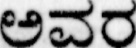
ಅವರ
